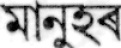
মানুহৰ
